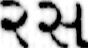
રસ
